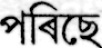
পৰিছে
